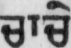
ਚਾਚੇ
